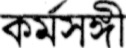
কর্মসঙ্গী
